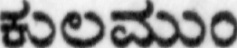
ಕುಲಮುಂ
